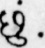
છું.
